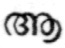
ആ
